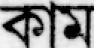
কাম
